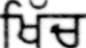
ਖਿੱਚ
